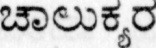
ಚಾಲುಕ್ಯರ
